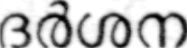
ദര്‍ശന
